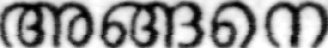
അങ്ങനെ
